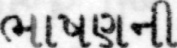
ભાષણની
